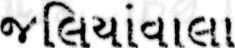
જલિયાંવાલા
